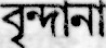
বৃন্দানা
